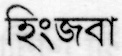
হিংজবা
